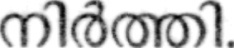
നിര്‍ത്തി.
